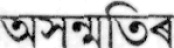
অসন্মতিৰ
